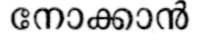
നോക്കാന്‍
